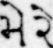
મેરે
